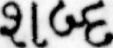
શબ્દ
